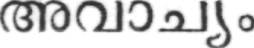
അവാച്യം
